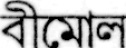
বীমোল
